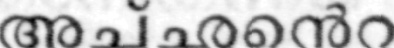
അച്ഛന്റെ
